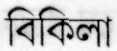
বিকিলা
